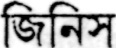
জিনিস
